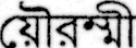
য়ৌরম্মী
